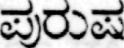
ಪುರುಷ
